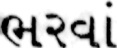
ભરવાં
